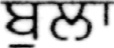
ਬੁਲਾ
